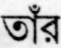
তাঁর
